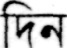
দিন
